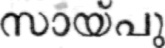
സായ്പു
